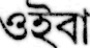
ওইবা
